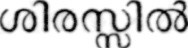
ശിരസ്സില്‍
